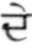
ਦੇ
